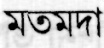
মতমদা
